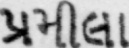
પ્રમીલા
